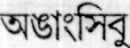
অঙাংসিবু
